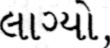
લાગ્યો,
